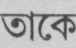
তাকে
